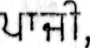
ਪਾਜੀ,
